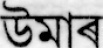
উমাৰ
